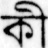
কী
